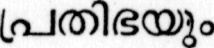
പ്രതിഭയും
